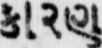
કારણ
